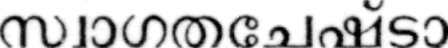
സ്വാഗതചേഷ്ടാ
